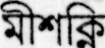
মীশক্নি
